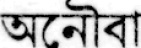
অনৌবা
